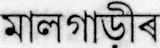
মালগাড়ীৰ
